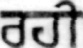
ਰਹੀ
